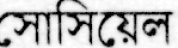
সোসিয়েল
